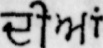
ਦੀਆਂ
